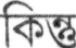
কিন্তু
